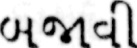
બજાવી
